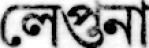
লেপ্তনা
